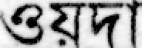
ওয়দা
